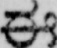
ಈ
